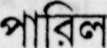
পারিল
